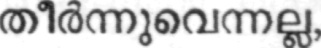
തീര്‍ന്നുവെന്നല്ല,
